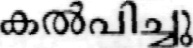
കല്‍പിച്ചു
